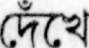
দেঁখে
